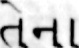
તેના
